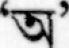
'অ'
